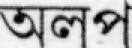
অলপ
